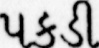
પકડી
